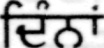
ਦਿੰਨਾਂ
